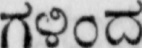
ಗಳಿಂದ
